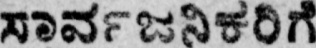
ಸಾರ್ವಜನಿಕರಿಗೆ
